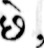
છે,
